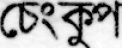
চেংকুপ
